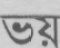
ভয়
